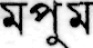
মপুম
